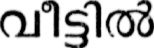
വീട്ടില്‍
